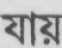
যায়
